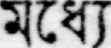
মধ্যে
